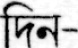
দিন-
